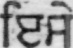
ਇਸੇ
